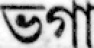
ভগা
